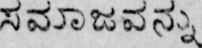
ಸಮಾಜವನ್ನು
